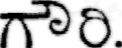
ಗೌರಿ.
